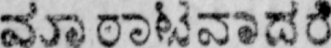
ಮಾರಾಟವಾದರೆ
